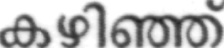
കഴിഞ്ഞ്
